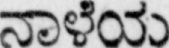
ನಾಳೆಯ
